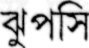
ঝুপসি
